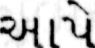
આપે
